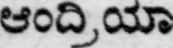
ಆ೦ದ್ರಿಯಾ
